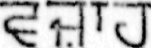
ਵਜ਼ਾਹ
